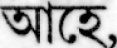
আহে,
